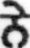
ਨੇ
